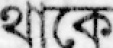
থাকে
